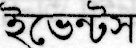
ইভেন্টস
